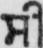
ਸੀ
